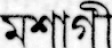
মশাগী
